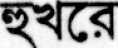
হুখরে
